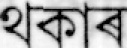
থকাৰ
